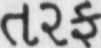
તરફ
